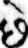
છે
